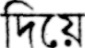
দিয়ে
